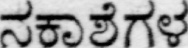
ನಕಾಶೆಗಳ
